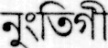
নুংতিগী
